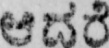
ಆದರೆ
